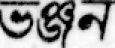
ভঞ্জন
